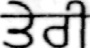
ਤੇਰੀ
